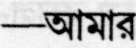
–আমার
